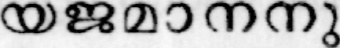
യജമാനനു
